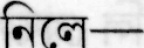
নিলে-
